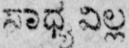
ಸಾಧ್ಯವಿಲ್ಲ
